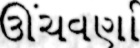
ઊંચવર્ણા
